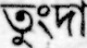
তুংদা
